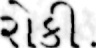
રોકી.
